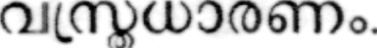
വസ്ത്രധാരണം.
